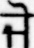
ਜੋ
